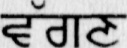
ਵੱਗਣ
